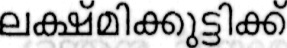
ലക്ഷ്മിക്കുട്ടിക്ക്
